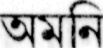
অমনি
